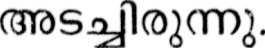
അടച്ചിരുന്നു.
